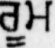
ਰੂਮ
